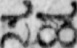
ಸಹ
